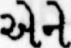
એને
